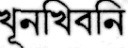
খূনখিবনি
